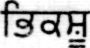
ਭਿਕਸ਼ੂ
